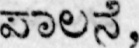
ಪಾಲನೆ,
